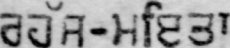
ਰਹੱਸ-ਮਇਤਾ
